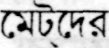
মেট্‌দের
